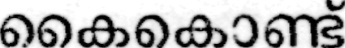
കൈകൊണ്ട്
